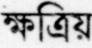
ক্ষত্রিয়
